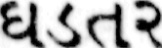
ઘડતર
